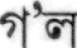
গ'ল
